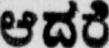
ಆದರೆ
